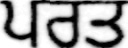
ਪਰਤ
